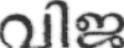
വിജ
